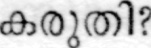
കരുതി?
